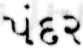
પંદર
